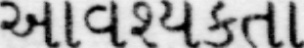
આવશ્યકતા
